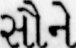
સૌને
